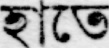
হাতে
